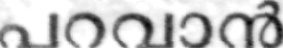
പറവാന്‍
